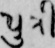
પુત્રી
